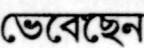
ভেবেছেন
